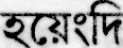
হয়েংদি
